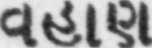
વહાણ
